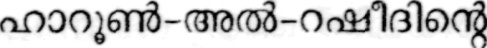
ഹാറൂണ്‍-അല്‍-റഷീദിൻ്റെ
